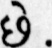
છે.
